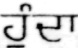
ਹੁੰਦਾ
